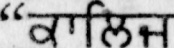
''ਕਾਲਿਜ
